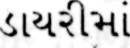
ડાયરીમાં
